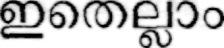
ഇതെല്ലാം
